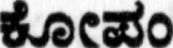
ಕೋಪಂ
